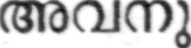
അവനു
